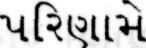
પરિણામે
